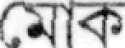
মোক
